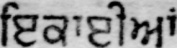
ਇਕਾਈਆਂ
